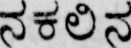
ನಕಲಿನ
